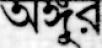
অঙ্গুর
